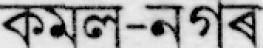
কমল-নগৰ
